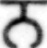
ਨ
